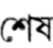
শেষ
